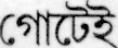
গোটেই
